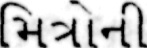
મિત્રોની
